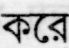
করে
